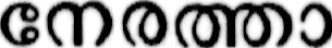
നേരത്താ
